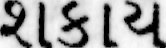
શકાય
